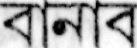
বানাব
